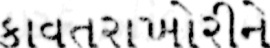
કાવતરાખોરીને
